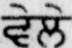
ਵੇਲੇ
